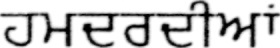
ਹਮਦਰਦੀਆਂ
